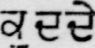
ਕੁਦਦੇ
